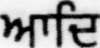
ਆਦਿ
